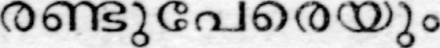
രണ്ടുപേരെയും
